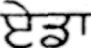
ਏਡਾ
